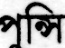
পুন্সি
